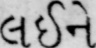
લઈને
